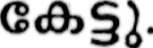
കേട്ടു.
